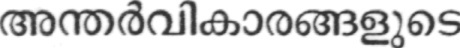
അന്തര്‍വികാരങ്ങളുടെ
